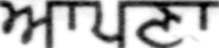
ਆਪਣਾ
